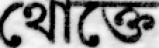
থোক্তে
